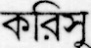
করিসু
